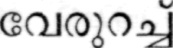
വേരുറച്ച്
